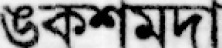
ঙকশমদা
